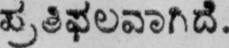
ಪ್ರತಿಫಲವಾಗಿದೆ.
